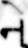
ને
